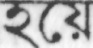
হয়ে
